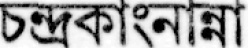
চন্দ্রকাংনান্না
